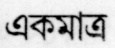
একমাত্র
